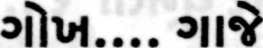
ગોખ........ગાજે
